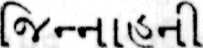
જિન્નાહની
